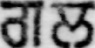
ਗਲ
